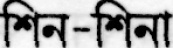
শিন-শিনা
